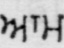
ਆਮ
